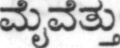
ಮೈವೆತ್ತು
